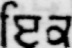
ਇਕ
